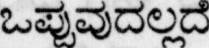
ಒಪ್ಪುವುದಲ್ಲದೆ
